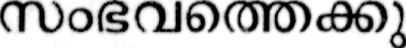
സംഭവത്തെക്കു
